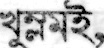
খুম্লমই,
